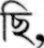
ছি,
